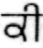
ਕੀ
